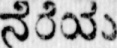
ನೆರೆಯ
